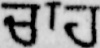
ਚਾਹ
